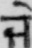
ਜੇ
